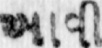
આવી
